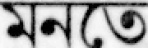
মনতে
